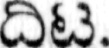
ದಿಟ.
